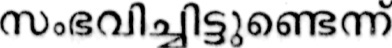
സംഭവിച്ചിട്ടുണ്ടെന്ന്
